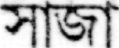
সাজা
